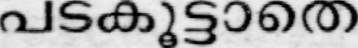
പടകൂട്ടാതെ
